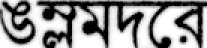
ঙম্লমদরে
